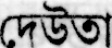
দেউতা
